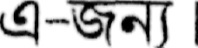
এ-জন্য।
